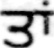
ਤਾਂ
